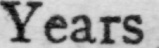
Years
